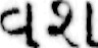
વશ
